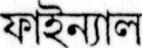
ফাইন্যাল
